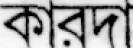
কারদা
